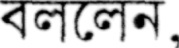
বললেন,
